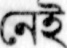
নেই
